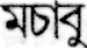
মচাবু
